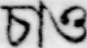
চাও
